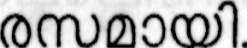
രസമായി.
